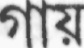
গায়
